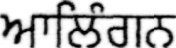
ਆਲਿੰਗਨ
